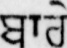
ਬਾਰੇ
